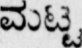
ಮಟ್ಟ
